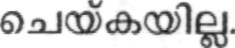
ചെയ്കയില്ല.
